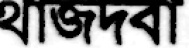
থাজদবা
